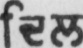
ਦਿਲ
